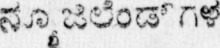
ನ್ಯೂಜಿಲೆಂಡ್‌ಗಳ
